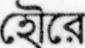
হৌরে
